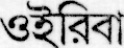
ওইরিবা
